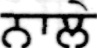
ਨਾਲੇ
